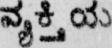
ವ್ಯಕ್ತಿಯ
